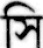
সি
